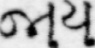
જાય
